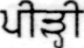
ਪੀੜ੍ਹੀ
